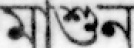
মাশুন
